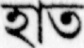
হাত
